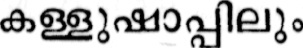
കള്ളുഷാപ്പിലും
